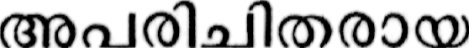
അപരിചിതരായ
